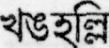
খঙহল্লি
